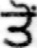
ਤੋਂ
